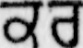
ਕਰ
